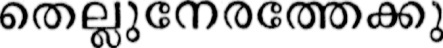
തെല്ലുനേരത്തേക്കു
